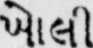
ખોલી
